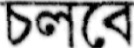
চলবে
